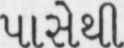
પાસેથી
